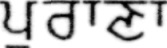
ਪੁਰਾਣਾ
